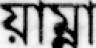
য়াম্না
